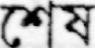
শেষ
